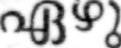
ഏഴു
